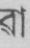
ৱা
